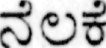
ನೆಲಕೆ
